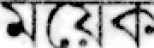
ময়েক
